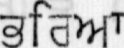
ਭਰਿਆ
